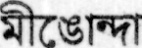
মীঙোন্দা
